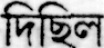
দিছিল
